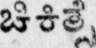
ಚಿಕಿತ್ಸೆ
